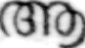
ആ
